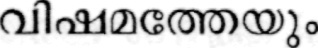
വിഷമത്തേയും
